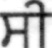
ਸੀ
